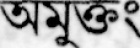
অমুক্তং
